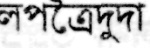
লপত্রৈদুদা
